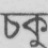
চকু
